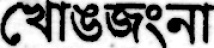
খোঙজংনা
